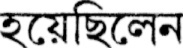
হয়েছিলেন
